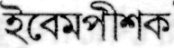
ইবেমপীশক
